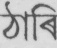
ঠাৰি
